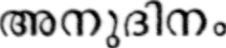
അനുദിനം
